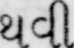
થવી
